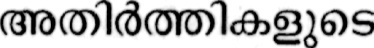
അതിര്‍ത്തികളുടെ
